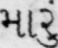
મારું
